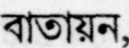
বাতায়ন,
